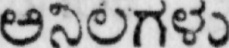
ಅನಿಲಗಳು
